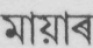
মায়াৰ
